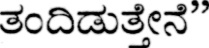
ತಂದಿಡುತ್ತೇನೆ"
